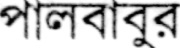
পালবাবুর
